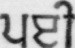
ਪਈ
